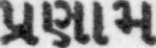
પ્રણામ
